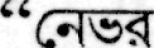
“নেভর
